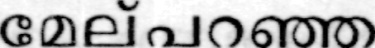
മേല്പറഞ്ഞ
